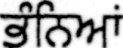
ਭੰਨਿਆ
